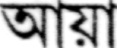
আয়া
